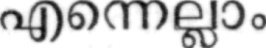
എന്നെല്ലാം
